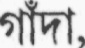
গাঁদা,
